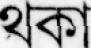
থকা
